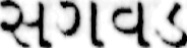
સગવડ
